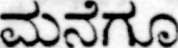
ಮನೆಗೂ
